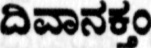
ದಿವಾನಕ್ತಂ
